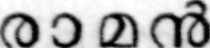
രാമന്‍
